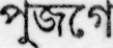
পুজগে
